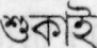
শুকাই
